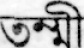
তম্মী
